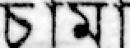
চামা
